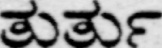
ತುರ್ತು
